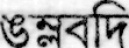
ঙম্লবদি
